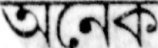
অনেক
